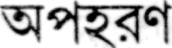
অপহরণ
